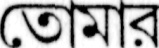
তোমার
